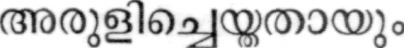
അരുളിച്ചെയ്തതായും
